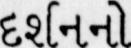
દર્શનનો
